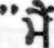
''ਮੈਂ
